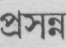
প্ৰসন্ন
